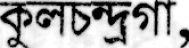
কুলচন্দ্রগা,
